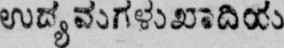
ಉದ್ಯಮಗಳುಖಾದಿಯ
